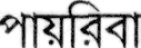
পায়রিবা
